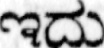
ಇದು
